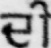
ਦੀ
